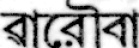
ৱারৌবা
